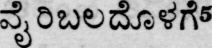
ವೈರಿಬಲದೊಳಗೆ5
